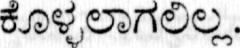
ಕೊಳ್ಳಲಾಗಲಿಲ್ಲ.
